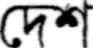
দেশ
